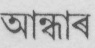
আন্ধাৰ
